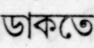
ডাকতে
